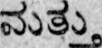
ಮತ್ತು
